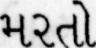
મરતો
